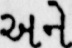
અને
